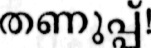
തണുപ്പ്!
